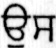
ਉਸ
